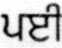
ਪਈ
